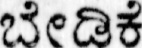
ಬೇಡಿಕೆ
